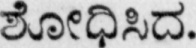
ಶೋಧಿಸಿದ.
